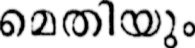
മെതിയും
